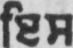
ਇਸ
